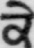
ਕੇ
